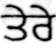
ਤੇਰੇ
